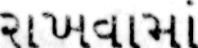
રાખવામાં
